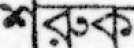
শরুক
